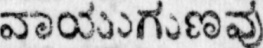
ವಾಯುಗುಣವು
